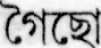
গৈছো
